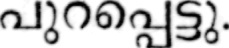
പുറപ്പെട്ടു.
